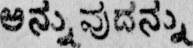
ಅನ್ನುವುದನ್ನು
